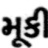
મૂકી
